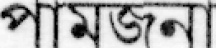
পামজনা
